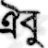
ঐবু
